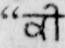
''ਕੀ
